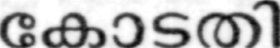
കോടതി
